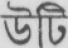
উটি
